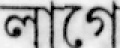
লাগে
